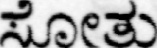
ಸೋತು
